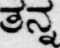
ತನ್ನ
